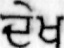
ਦੇਖ
